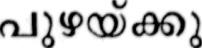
പുഴയ്ക്കു
